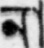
না
